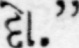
દો."
